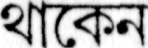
থাকেন
